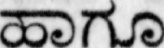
ಹಾಗೂ
